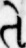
તે
